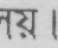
লয়।
